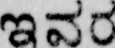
ಇವರ
